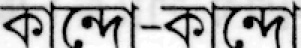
কান্দো-কান্দো
